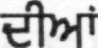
ਦੀਆਂ
